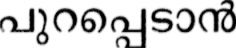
പുറപ്പെടാന്‍
